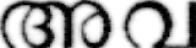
അവ
